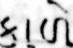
કાળે
